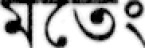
মতেং
